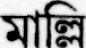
মাল্লি
